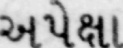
અપેક્ષા
